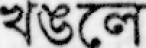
খঙলে
